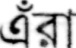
এঁরা
